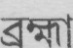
ব্ৰহ্মা
